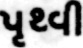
પૃથ્વી
